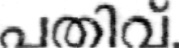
പതിവ്.
